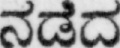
ನಡೆದ
